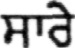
ਸਾਰੇ
